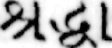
શ્રદ્ધા
